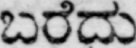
ಬರೆದು
